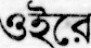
ওইরে
